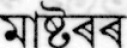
মাষ্টৰৰ
